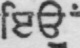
ਇਉਂ
